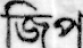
জিপ
